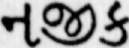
નજીક
